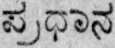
ಪ್ರಧಾನ
